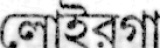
লোইরগা
